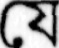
যে
